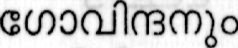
ഗോവിന്ദനും
